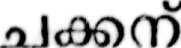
ചക്കന്
